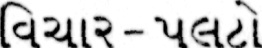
વિચાર-પલટો
